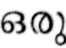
ഒരു
